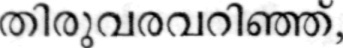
തിരുവരവറിഞ്ഞ്,
